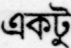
একটু
